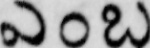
ಎಂಬ
